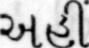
અહીં
